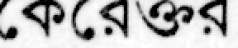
কেরেক্তর
